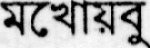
মখোয়বু
